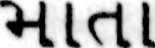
માતા
